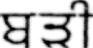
ਬੜੀ
